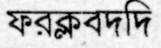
ফরক্লবদদি
